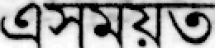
এসময়ত
